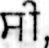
ਸੀ,
